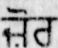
ਜ਼ੋਰ
